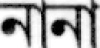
নানা
